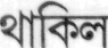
থাকিল
